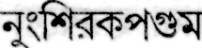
নুংশিরকপগুম
